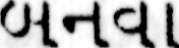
બનવા
